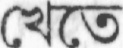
খেতে
